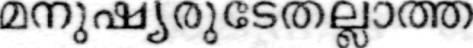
മനുഷ്യരുടേതല്ലാത്ത
